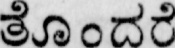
ತೊಂದರೆ
